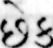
છેક
